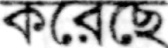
করেছে
